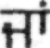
ਜਾਂ
